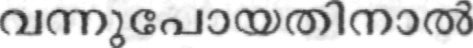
വന്നുപോയതിനാല്‍
